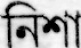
নিশা
